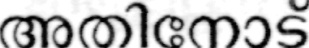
അതിനോട്
